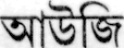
আউজি
